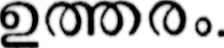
ഉത്തരം.
